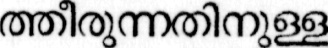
ത്തീരുന്നതിനുള്ള
